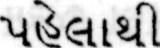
પહેલાથી
